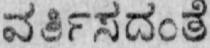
ವರ್ತಿಸದಂತೆ
